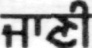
ਜਾਣੀ
